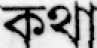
কথা
